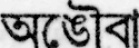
অঙৌবা
